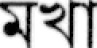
মখা
